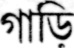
গাড়ি
